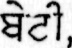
ਬੇਟੀ,
